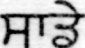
ਸਾਡੇ
